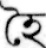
হৈ
